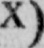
x)
